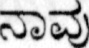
ನಾವು
